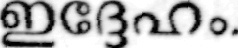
ഇദ്ദേഹം.
